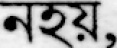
নহয়,
